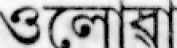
ওলোৱা
